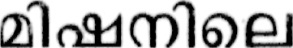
മിഷനിലെ
